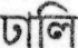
ঢালি
